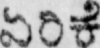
ಏರಿಕೆ
